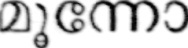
മൂന്നോ
